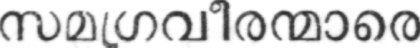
സമഗ്രവീരന്മാരെ
